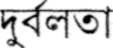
দুর্বলতা
